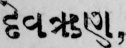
દેવઋણ,
